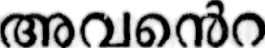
അവന്റെ
